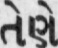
તેણે
